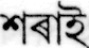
শৰাই
